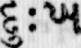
દુઃખ
